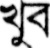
খুব
